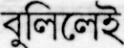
বুলিলেই
